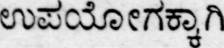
ಉಪಯೋಗಕ್ಕಾಗಿ
